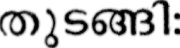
തുടങ്ങി:
